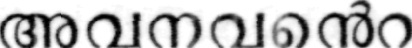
അവനവന്റെ
